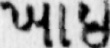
ખાઈ
